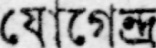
যোগেন্দ্র
